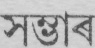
সম্ভাৰ
